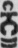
ਨੂੰ
